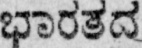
ಭಾರತದ
